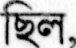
ছিল,
